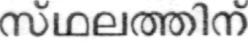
സ്ഥലത്തിന്
